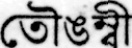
তৌঙম্বী
